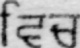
ਵਿਚ
